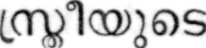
സ്ത്രീയുടെ
